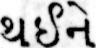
થઈને
